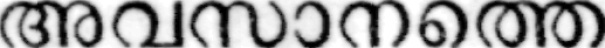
അവസാനത്തെ
